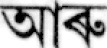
আৰু
